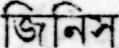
জিনিস
